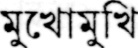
মুখোমুখি
